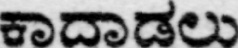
ಕಾದಾಡಲು
